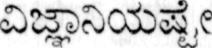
ವಿಜ್ಞಾನಿಯಷ್ಟೇ
